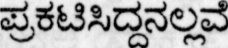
ಪ್ರಕಟಿಸಿದ್ದನಲ್ಲವೆ
